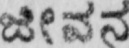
ಜೀವನ
